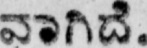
ವಾಗಿದೆ.
